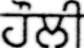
ਹੌਲੀ
